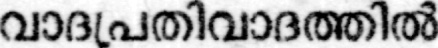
വാദപ്രതിവാദത്തില്‍
